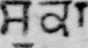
ਸੁਕਾ
